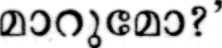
മാറുമോ?’
